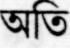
অতি
